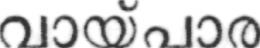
വായ്പാര
